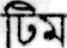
টিম
